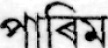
পাৰিম
